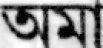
অমা
